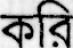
করি
